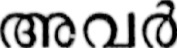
അവര്‍
